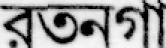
রতনগা
